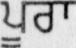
ਪੂਰਾ
